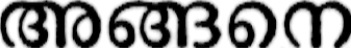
അങ്ങനെ
